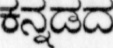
ಕನ್ನಡದ
